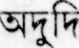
অদুদি
